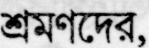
শ্রমণদের,
